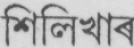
শিলিখাৰ
